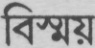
বিস্ময়
